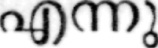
എന്നു
